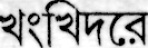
খংখিদরে
